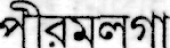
পীরমলগা
